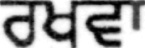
ਰਖਵਾ
